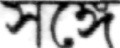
সঙ্গে
